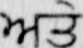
ਅਤੇ
